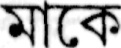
মাকে
